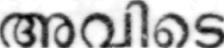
അവിടെ
